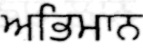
ਅਭਿਮਾਨ
